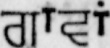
ਗਾਵਾਂ
